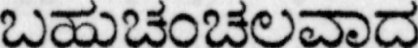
ಬಹುಚಂಚಲವಾದ
